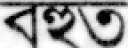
বহুত
